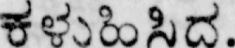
ಕಳುಹಿಸಿದ.
